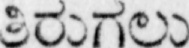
ತಿರುಗಲು
